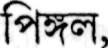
পিঙ্গল,
